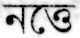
নত্তে
